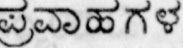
ಪ್ರವಾಹಗಳ
